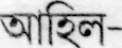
আহিল-
